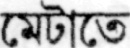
মেটাতে
